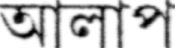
আলাপ
